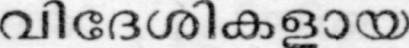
വിദേശികളായ
